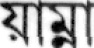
য়াম্না
